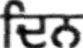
ਦਿਨ
